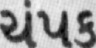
ચંપક
